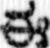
ಈ
